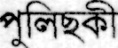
পুলিছকী
